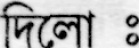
দিলোঃ
